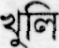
খুলি
